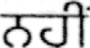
ਨਹੀਂ
